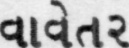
વાવેતર
